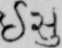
ઈસુ
